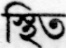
স্থিত
